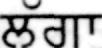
ਲੱਗਾ
